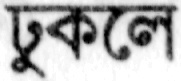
ঢুকলে
